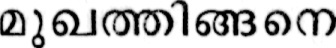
മുഖത്തിങ്ങനെ
